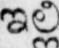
ಇಲ್ಲಿ
